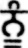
ਨੂੰ
